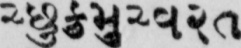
ચ્છુક્રમુચ્વરત
